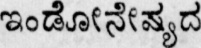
ಇಂಡೋನೇಷ್ಯದ
